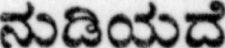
ನುಡಿಯದೆ
